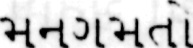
મનગમતો
